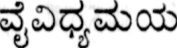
ವೈವಿಧ್ಯಮಯ
